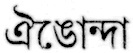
ঐঙোন্দা
